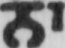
ਨਾ
